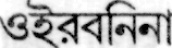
ওইরবনিনা
